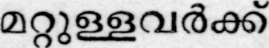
മറ്റുള്ളവര്‍ക്ക്
